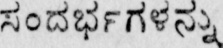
ಸಂದರ್ಭಗಳನ್ನು
